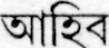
আহিব
